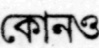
কোনও
